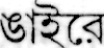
ঙাইরে
